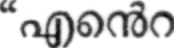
“എന്റെ
